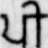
ਪੀ
